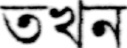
তখন
